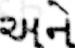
અને
